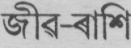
জীৱ-ৰাশি
